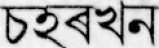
চহৰখন
